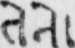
તેનો
